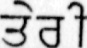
ਤੇਰੀ
